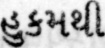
હુકમથી
